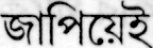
জাপিয়েই
